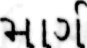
માર્ગ
